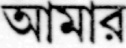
আমার
